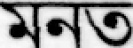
মনত
